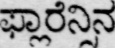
ಫ್ಲಾರೆನ್ಸಿನ
